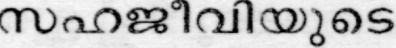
സഹജീവിയുടെ
